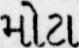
મોટા
